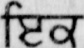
ਇਕ
